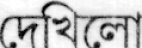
দেখিলো
